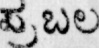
ಪ್ರಬಲ
